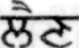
ਲੈਣ
